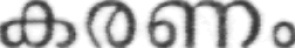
കരണം
